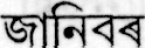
জানিবৰ
